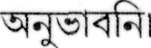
অনুভাবনি।
